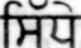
ਸਿੱਧੇ
